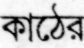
কাঠের
